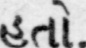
હતો.
